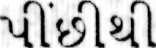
પીંછીથી
